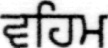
ਵਹਿਮ
